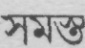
সমস্ত
